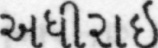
અધીરાઈ
